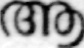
ആ
